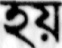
হয়
